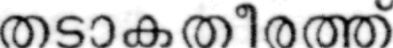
തടാകതീരത്ത്
